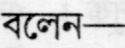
বলেন–
